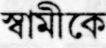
স্বামীকে
